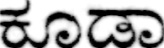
ಕೂಡಾ
